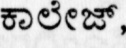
ಕಾಲೇಜ್,
